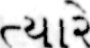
ત્યારે
